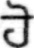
ਹੋ
